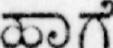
ಹಾಗೆ
